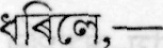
ধৰিলে,-
